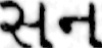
સન
